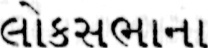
લોકસભાના
